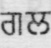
ਗਲ
